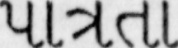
પાત્રતા
